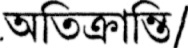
অতিক্রান্তি।
